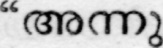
"അന്നു
